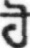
ਹੋ
